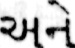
અને
